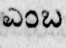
ಎಂಬ
